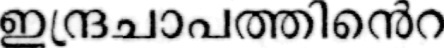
ഇന്ദ്രചാപത്തിന്റെ
